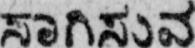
ಸಾಗಿಸುವ
